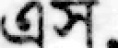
এস.
